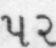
પર
